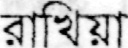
রাখিয়া
